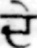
ਦੇ
